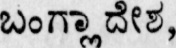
ಬಂಗ್ಲಾದೇಶ,
